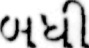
બધી
